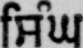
ਸਿੰਘ
